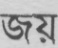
জয়
